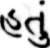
હતું
